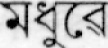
মধুৱে
